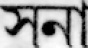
সনা
